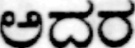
ಅದರ
